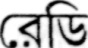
রেডি
